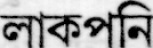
লাকপনি
